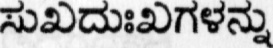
ಸುಖದುಃಖಗಳನ್ನು
